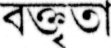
বক্তৃতা
